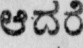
ಆದರೆ
